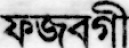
ফজবগী
